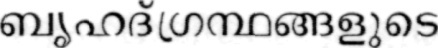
ബൃഹദ്ഗ്രന്ഥങ്ങളുടെ
